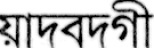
য়াদবদগী
